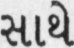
સાથે
